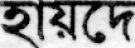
হায়দে
